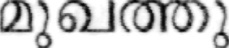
മുഖത്തു
